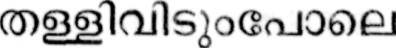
തള്ളിവിടുംപോലെ
